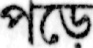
পড়ে
